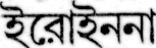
ইরোইননা
